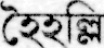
হৈহল্লি
